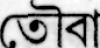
তৌবা
